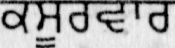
ਕਸੂਰਵਾਰ
